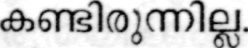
കണ്ടിരുന്നില്ല.
